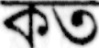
কত
